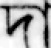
দা
